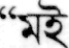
"মই
